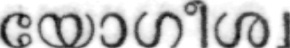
യോഗീശ്വ
